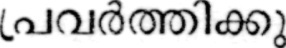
പ്രവര്‍ത്തിക്കു
